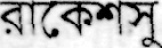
রাকেশসু
